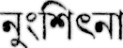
নুংশিৎনা
